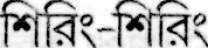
শিরিং-শিরিং
